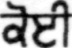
ਕੋਈ
